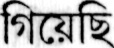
গিয়েছি
